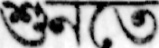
শুনতে
